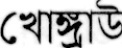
খোঙ্গ্রাউ
